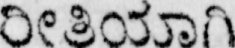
ರೀತಿಯಾಗಿ
